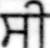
ਸੀ
